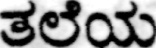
ತಲೆಯ
